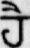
ਹੈ
